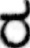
ರ
